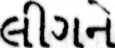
લીગને
